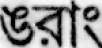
ঙরাং
